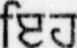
ਇਹ
